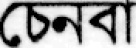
চেনবা
